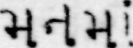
મનમાં
